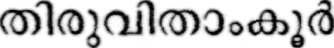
തിരുവിതാംകൂര്‍
